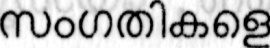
സംഗതികളെ
